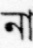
না
